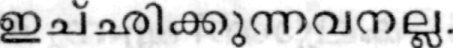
ഇച്ഛിക്കുന്നവനല്ല.
